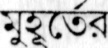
মুহূর্তের
